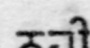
ਨਹੀਂ
